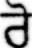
ਰੋ
